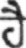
ਹੈ
